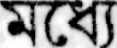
মধ্যে
